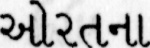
ઓરતના
